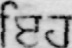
ਇਹ
